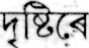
দৃষ্টিৰে
